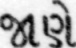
જાણે
